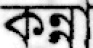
কন্না
